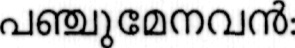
പഞ്ചുമേനവന്‍:
